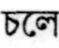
চলে
